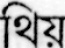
থিয়
